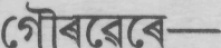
গৌৰৱেৰে-
